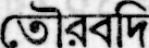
তৌরবদি
